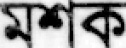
মশক
